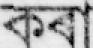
কৰা
